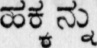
ಹಕ್ಕನ್ನು
